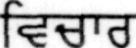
ਵਿਚਾਰ
